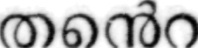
തന്റെ
